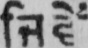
ਜਿਵੇਂ
